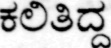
ಕಲಿತಿದ್ದ
